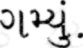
ગમ્યું.
